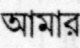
আমার
